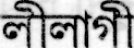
লীলাগী
